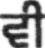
ਵੀ
